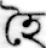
হৈ
